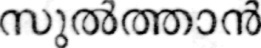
സുല്‍ത്താന്‍
